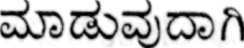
ಮಾಡುವುದಾಗಿ
